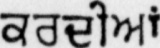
ਕਰਦੀਆਂ
